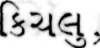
કિચલુ,
